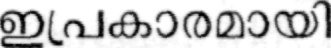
ഇപ്രകാരമായി
